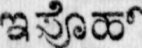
ಇಪೊಹ್
